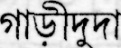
গাড়ীদুদা
